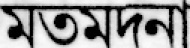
মতমদনা
